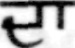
ਦਾ
